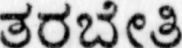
ತರಬೇತಿ
